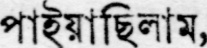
পাইয়াছিলাম,
